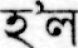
হ'ল
